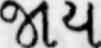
જાય
